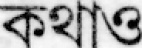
কথাও
